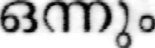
ഒന്നും
